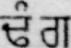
ਢੰਗ
